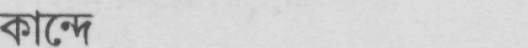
কান্দে
